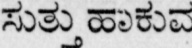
ಸುತ್ತುಹಾಕುವ
